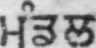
ਮੰਡਲ
